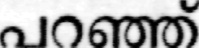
പറഞ്ഞ്
